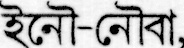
ইনৌ-নৌবা,
